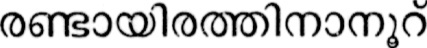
രണ്ടായിരത്തിനാനൂറ്
